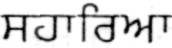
ਸਹਾਰਿਆ
